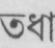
তধা
